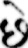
છે
